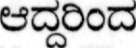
ಆದ್ದರಿಂದ
